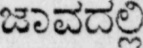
ಜಾವದಲ್ಲಿ
